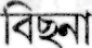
বিছনা
